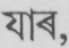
যাৰ,
